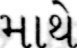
માથે
